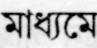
মাধ্যমে
